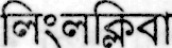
লিংলক্লিবা
